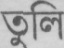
তুলি
